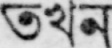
তখন
